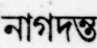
নাগদন্ত
